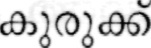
കുരുക്ക്
